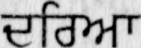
ਦਰਿਆ
